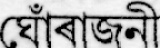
ঘোঁৰাজনী
